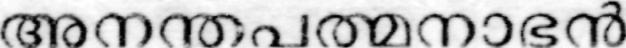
അനന്തപത്മനാഭന്‍
